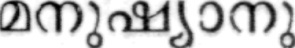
മനുഷ്യാനു
